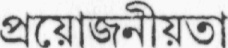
প্রয়োজনীয়তা
